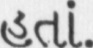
હતાં.
